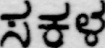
ಸಕಳ
